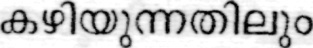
കഴിയുന്നതിലും
